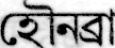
হৌনব্রা
